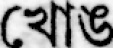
খোঙ
